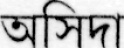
অসিদা
